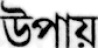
উপায়
